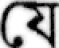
যে
